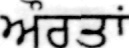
ਔਰਤਾਂ
